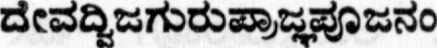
ದೇವದ್ವಿಜಗುರುಪ್ರಾಜ್ಞಪೂಜನಂ
